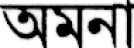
অমনা
